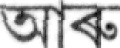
আৰু
